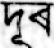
দূৰ
